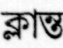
ক্লান্ত
